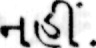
નહીં.
